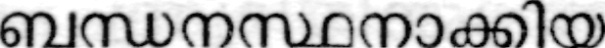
ബന്ധനസ്ഥനാക്കിയ
